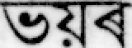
ভয়ৰ
